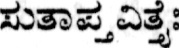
ಸುತಾಪ್ತವಿತೈಃ
